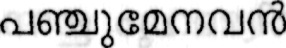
പഞ്ചുമേനവന്‍
